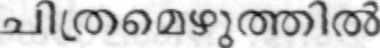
ചിത്രമെഴുത്തില്‍
